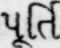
પૂર્તિ
